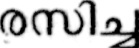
രസിച്ച
